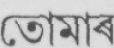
তোমাৰ
